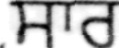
ਸਾਰ
